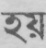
হয়
